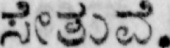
ಸೇತುವೆ.
